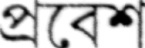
প্রবেশ
